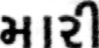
મારી
